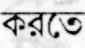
করতে
